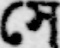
সে
